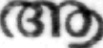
ആ
